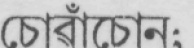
চোৱাঁচোন;
